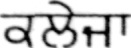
ਕਲੇਜਾ
